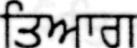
ਤਿਆਗ
